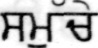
ਸਮੁੱਚੇ
